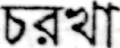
চরখা
